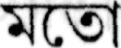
মতো
